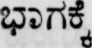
ಭಾಗಕ್ಕೆ
